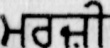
ਮਰਜ਼ੀ
